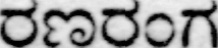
ರಣರ೦ಗ
